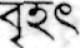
বৃহৎ
